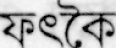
ফৎকৈ
